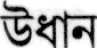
উধান
